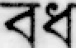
বধ
